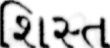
શિસ્ત
